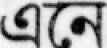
এনে
